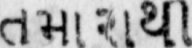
તમારાથી
